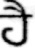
ਹੈ
